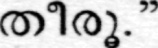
തീരൂ."
